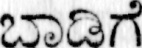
ಬಾಡಿಗೆ
